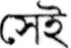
সেই
